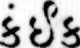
કંઈક
